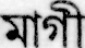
মাগী
